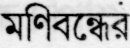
মণিবন্ধের
